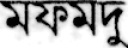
মফমদু
